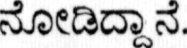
ನೋಡಿದ್ದಾನೆ.
